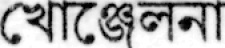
খোঞ্জেলনা
